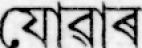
যোৱাৰ
